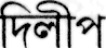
দিলীপ
